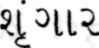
શૃંગાર
